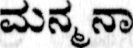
ಮನ್ಮನಾ
